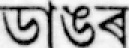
ডাঙৰ
